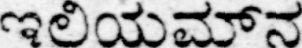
ಇಲಿಯಮ್ನ
